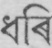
ধৰি
